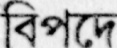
বিপদে
